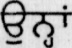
ਉਨ੍ਹਾਂ
